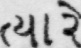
ત્યારે
